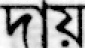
দায়
